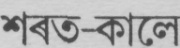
শৰত-কালে
